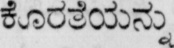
ಕೊರತೆಯನ್ನು
